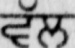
ਵੱਲ
